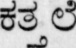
ಕತ್ತಲೆ
